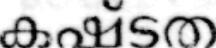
കഷ്ടത
